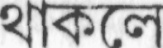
থাকলে
